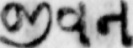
જીવન
